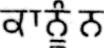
ਕਾਨੂੰਨ
